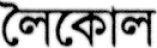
লৈকোল
